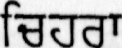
ਚਿਹਰਾ
